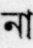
না
